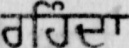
ਰਹਿੰਦਾ
